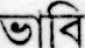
ভাবি
